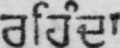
ਰਹਿੰਦਾ
